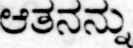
ಆತನನ್ನು
